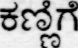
ಕಣ್ಣಿಗೆ
